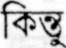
কিন্তু
